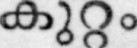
കുറ്റം
